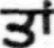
ਤਾਂ
